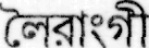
লৈরাংগী
